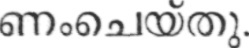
ണംചെയ്തു.
